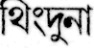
থিংদুনা
